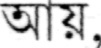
আয়,
